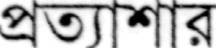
প্রত্যাশার
